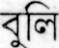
বুলি
